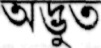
অদ্ভুত
